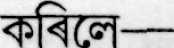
কৰিলে-
